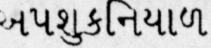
અપશુકનિયાળ
